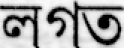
লগত
